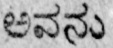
ಅವನು
